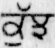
ਕੁੱਝ
